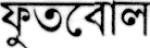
ফুতবোল
